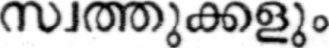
സ്വത്തുക്കളും
